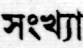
সংখ্যা
